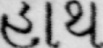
હાથ
